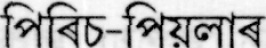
পিৰিচ-পিয়লাৰ
